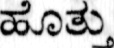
ಹೊತ್ತು
